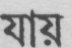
যায়
